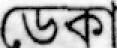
ডেকা
